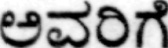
ಅವರಿಗೆ
